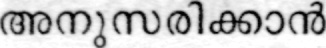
അനുസരിക്കാന്‍
